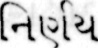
નિર્ણય
